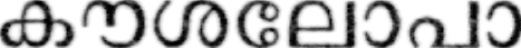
കൌശലോപാ
